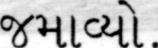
જમાવ્યો.
